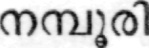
നമ്പൂരി
